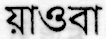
য়াওবা
